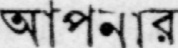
আপনার
